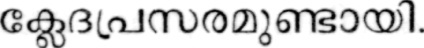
ക്ലേദപ്രസരമുണ്ടായി.
